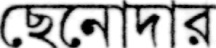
ছেনোদার
